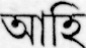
আহি
